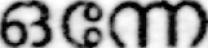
ഒന്നേ
